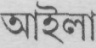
আইলা
